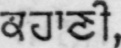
ਕਹਾਣੀ,
